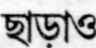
ছাড়াও
